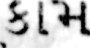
કામ
